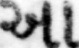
આ
